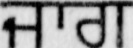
ਜਾਗ
